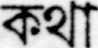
কথা
